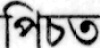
পিচত
